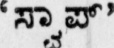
‘ಸ್ವಾಪ್’
